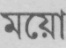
ময়ো
